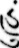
હું
